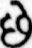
છે
